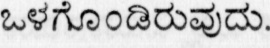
ಒಳಗೊಂಡಿರುವುದು.
